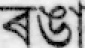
ৰঙা
